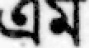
এম
